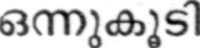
ഒന്നുകൂടി
